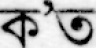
ক'ত
